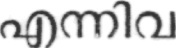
എന്നിവ
